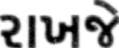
રાખજે
